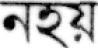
নহয়
